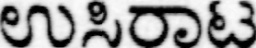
ಉಸಿರಾಟ
